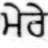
ਮੇਰੇ
